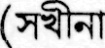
(সখীনা
